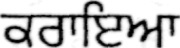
ਕਰਾਇਆ
